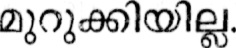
മുറുക്കിയില്ല.
